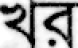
খর
